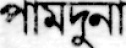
পামদুনা
